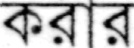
করার
